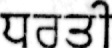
ਧਰਤੀ
